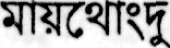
মায়থোংদু
